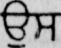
ਉਸ
